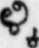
ಳ್ಕಿ
